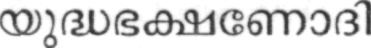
യുദ്ധഭക്ഷണോദി
